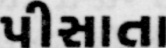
પીસાતા
